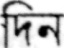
দিন
